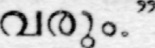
വരും."
